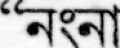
“নংনা
